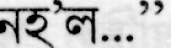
নহ'ল..."
